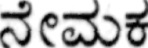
ನೇಮಕ
